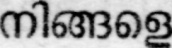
നിങ്ങളെ
